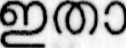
ഇതാ
